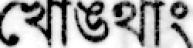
খোঙথাং
